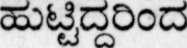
ಹುಟ್ಟಿದ್ದರಿಂದ
